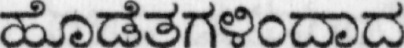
ಹೊಡೆತಗಳಿಂದಾದ
